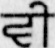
ਵੀ
